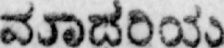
ಮಾದರಿಯ
